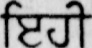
ਇਹੀ
